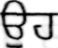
ਉਹ
